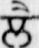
ਲੈ
